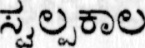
ಸ್ವಲ್ಪಕಾಲ
